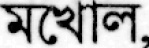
মখোল,
